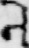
ને
